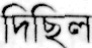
দিছিল
